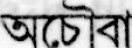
অচৌবা
